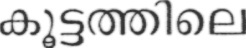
കൂട്ടത്തിലെ
